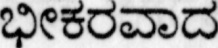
ಭೀಕರವಾದ
